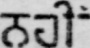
ਨਹੀਂ
